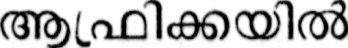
ആഫ്രിക്കയില്‍
